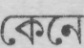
কেনে
